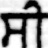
ਸੀ
